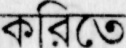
করিতে
